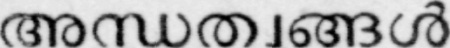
അന്ധത്വങ്ങള്‍
